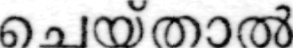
ചെയ്താല്‍
